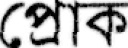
প্রোক
